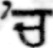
'ਚ
